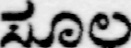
ಸೂಲ
